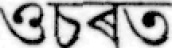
ওচৰত
